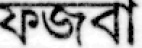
ফজবা
